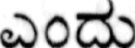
ಎಂದು
